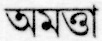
অমত্তা
